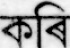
কৰি
